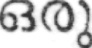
ഒരു
